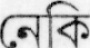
নেকি
